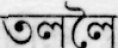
তললৈ
